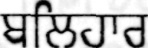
ਬਲਿਹਾਰ
